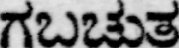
ಗಬಚುತ
